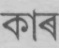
কাৰ
